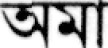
অমা
